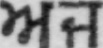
ਅਜ
